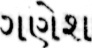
ગણેશ
